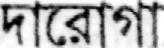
দারোগা
